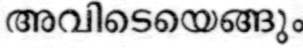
അവിടെയെങ്ങും
